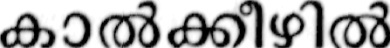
കാല്‍ക്കീഴില്‍
